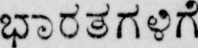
ಭಾರತಗಳಿಗೆ
